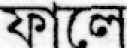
ফালে
